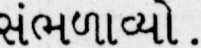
સંભળાવ્યો.
